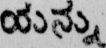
ಯನ್ನು
